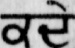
ਕਦੇ
